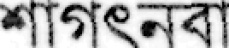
শাগৎনবা
